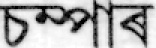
চম্পাৰ
